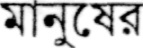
মানুষের
